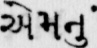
એમનું
